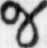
જ
